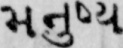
મનુષ્ય
